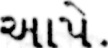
આપે.
